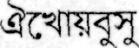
ঐখোয়বুসু
